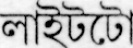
লাইটটো
